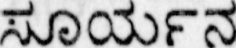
ಸೂರ್ಯನ
